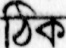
ঠিক
